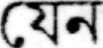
যেন
